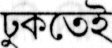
ঢুকতেই
